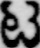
ಟ
